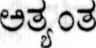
ಅತ್ಯಂತ
